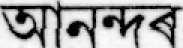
আনন্দৰ
